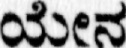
ಯೇನ
